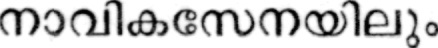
നാവികസേനയിലും
